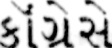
કૉંગ્રેસે
